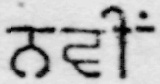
ਨਵੀਂ
